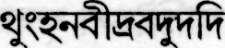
থুংহনবীদ্রবদুদদি
